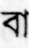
বা
